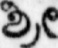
ಶ್ರೀ
